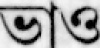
ভাও
